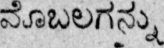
ಮೊಬಲಗನ್ನು
